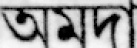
অমদা
